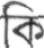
কি
